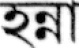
হন্না
